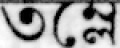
তম্লে
